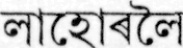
লাহোৰলৈ
